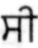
ਸੀ
